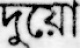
দুয়ো
